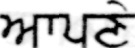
ਆਪਣੇ
